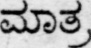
ಮಾತ್ರ
